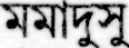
মমাদুসু
